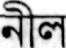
নীল
